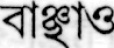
বাঞ্ছাও
